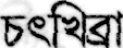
চৎখিব্রা
